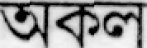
অকল
